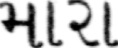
મારા
